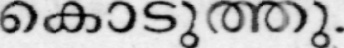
കൊടുത്തു.
